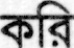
করি
